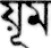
য়ূম
